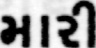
મારી
